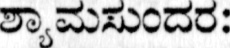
ಶ್ಯಾಮಸುಂದರ:
